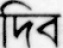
দিব
